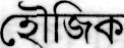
হৌজিক
